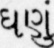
ઘણું
